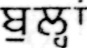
ਬੁਲ੍ਹਾਂ
